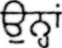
ਉਨ੍ਹਾਂ
